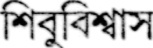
শিবুবিশ্বাস
